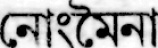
নোংমৈনা
